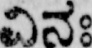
ವಿನಃ
